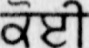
ਕੋਈ
